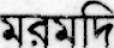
মরমদি
